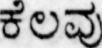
ಕೆಲವು
